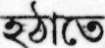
হঠাতে
